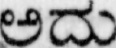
ಅದು
